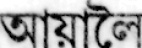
আয়ালৈ
